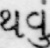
થવું
